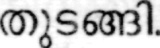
തുടങ്ങി.
